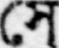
সে
